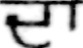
ਦਾ
